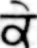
ਕੇ
